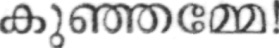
കുഞ്ഞമ്മേ!
